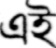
এই
